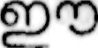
ഈ
